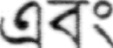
এবং
